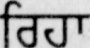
ਰਿਹਾ
